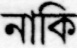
নাকি
